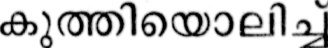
കുത്തിയൊലിച്ച്
